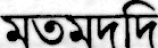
মতমদদি
